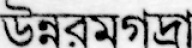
উন্নরমগদ্রা
